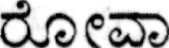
ರೋವಾ
